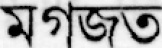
মগজত
